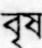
বৃষ
